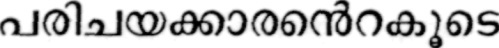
പരിചയക്കാരന്റെകൂടെ
